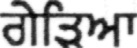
ਗੇੜਿਆ
